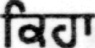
ਕਿਹਾ
